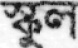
স্কুল
